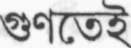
গুণতেই
